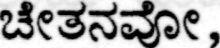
ಚೇತನವೋ,
